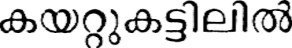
കയറ്റുകട്ടിലില്‍
